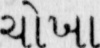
ચોખા
